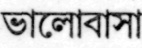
ভালোবাসা
